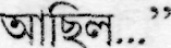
আছিল..."
